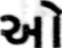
ઓ
